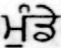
ਮੁੰਡੇ
